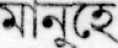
মানুহে
